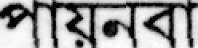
পায়নবা
